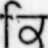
ਕਿ
